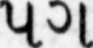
પગ
